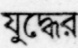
যুদ্ধের
